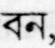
বন,
